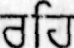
ਰਹਿ
